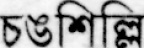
চঙশিল্লি
